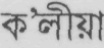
ক'লীয়া
